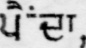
ਪੈਂਦਾ,
